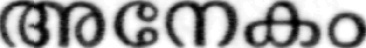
അനേകം
